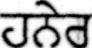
ਹਨੇਰ
